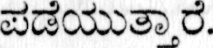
ಪಡೆಯುತ್ತಾರೆ.
